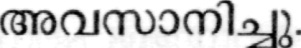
അവസാനിച്ചു.
